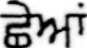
ਛੇਆਂ
